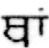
ਥਾਂ
